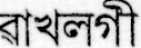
ৱাখলগী
